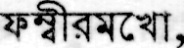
ফম্বীরমখো,
